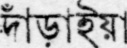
দাঁড়াইয়া
